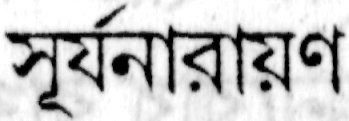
সূর্যনারায়ণ
